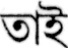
তাই
